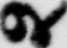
જ
